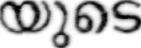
യുടെ
